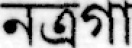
নত্রগা
